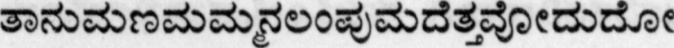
ತಾನುಮಣಮಮ್ಮನಲಂಪುಮದೆತ್ತವೋದುದೋ
